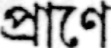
প্রাণে
